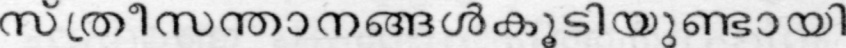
സ്ത്രീസന്താനങ്ങള്‍കൂടിയുണ്ടായി
